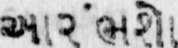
આરંભશો
